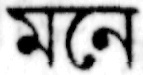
মনে
